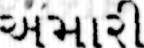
અમારી
